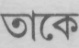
তাকে
